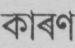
কাৰণ
